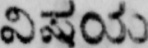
ವಿಷಯ
